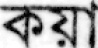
কয়া
